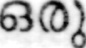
ഒരു
